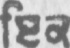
ਇਕ
